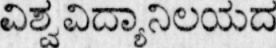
ವಿಶ್ವವಿದ್ಯಾನಿಲಯದ
